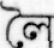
লৈ
